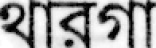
থারগা
